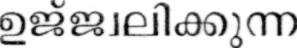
ഉജ്ജ്വലിക്കുന്ന
